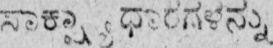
ಸಾಕ್ಷ್ಯಾಧಾರಗಳನ್ನು
